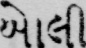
બોલી
